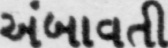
અંબાવતી
